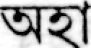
অহা
